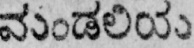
ಮಂಡಲಿಯ
